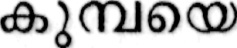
കുമ്പയെ
